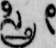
ಸ್ತ್ರೀ
